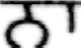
ਨਾ
